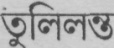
তুলিলন্ত
